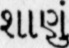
શાણું
